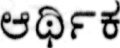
ಆರ್ಥಿಕ
